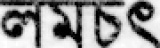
লমচৎ
